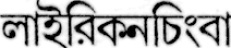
লাইরিকনচিংবা
